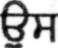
ਉਸ
